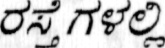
ರಸ್ತೆಗಳಲ್ಲಿ
